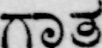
ಗಾತ
